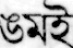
ঙমই
